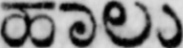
ಹಾಲು
